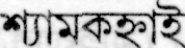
শ্যামকহ্ণাই
